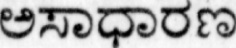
ಅಸಾಧಾರಣ
